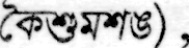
কৈশুমশঙ),
